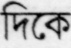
দিকে
